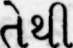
તેથી
